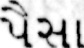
પૈસા
